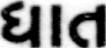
ધાત
